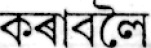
কৰাবলৈ
